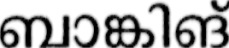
ബാങ്കിങ്
